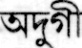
অদুগী
